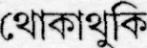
থোকাথুকি
